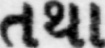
તથા
